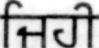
ਜਿਹੀ
